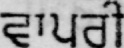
ਵਾਪਰੀ
